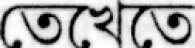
তেখেতে
